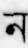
ন
